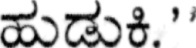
ಹುಡುಕಿ."
